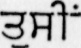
ਤੁਸੀਂ
